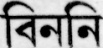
বিননি
